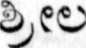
ಶ್ರೀಲ
